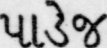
પાડેજ
